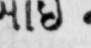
ખાઈ
